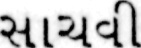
સાચવી
